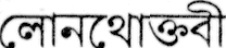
লোনথোক্তবী
